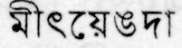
মীৎয়েঙদা
